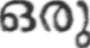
ഒരു
